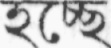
হচ্ছে
